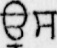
ਉਸ
